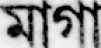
মাগা
